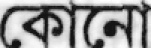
কোনো
